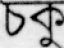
চকু
